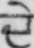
ਦੇ
